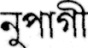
নুপাগী
